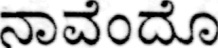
ನಾವೆಂದೊ
